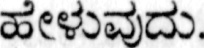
ಹೇಳುವುದು.
